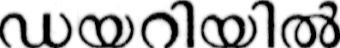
ഡയറിയില്‍
